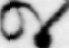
જ
